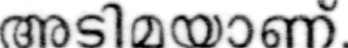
അടിമയാണ്.
